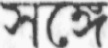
সঙ্গে
